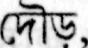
দৌড়,
